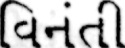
વિનંતી
